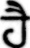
ਹੈ
